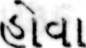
હોવા
